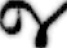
જ
